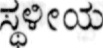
ಸ್ಥಳೀಯ
